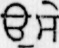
ਉਸੇ
